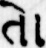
તો
